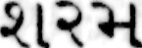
શરમ
